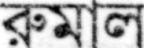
রুমাল
